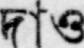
দাও
